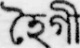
হৈগী
